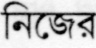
নিজের
